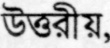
উত্তরীয়,
